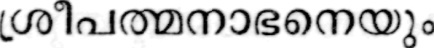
ശ്രീപത്മനാഭനെയും
